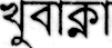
খুবাক্না
